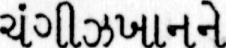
ચંગીઝખાનને
